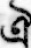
ঐ
